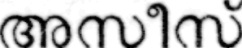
അസീസ്
